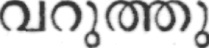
വറുത്തു
